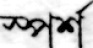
স্পর্শ
